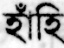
হাঁহি
